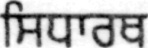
ਸਿਧਾਰਥ
